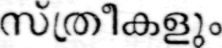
സ്ത്രീകളും
